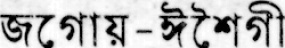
জগোয়-ঈশৈগী
